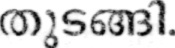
തുടങ്ങി.
